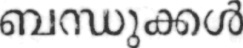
ബന്ധുക്കള്‍
